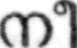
നീ
